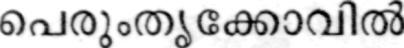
പെരുംതൃക്കോവില്‍
